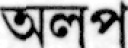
অলপ
